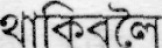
থাকিবলৈ
